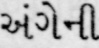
અંગેની
